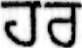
ਹਰ
